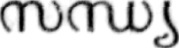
സന്ധ്യ
